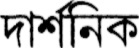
দার্শনিক
